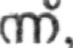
ന്ന്,
